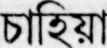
চাহিয়া
